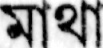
মাথা
